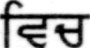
ਵਿਚ
